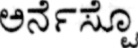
ಅರ್ನೆಸ್ಟೊ
